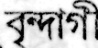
বৃন্দাগী
